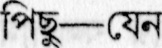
পিছু–যেন
